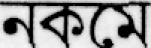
নকমে
